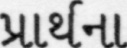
પ્રાર્થના
